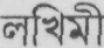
লখিমী
